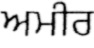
ਅਮੀਰ
